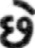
છે
